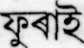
ফুৰাই
